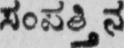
ಸಂಪತ್ತಿನ
